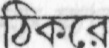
ঠিকরে
